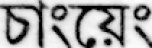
চাংয়েং
